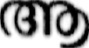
ആ
